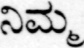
ನಿಮ್ಮ
